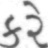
કરે
